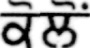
ਕੋਲੋਂ
